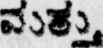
ಮತ್ತು
